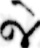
જે
